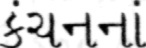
કંચનનાં
